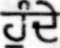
ਹੁੰਦੇ
